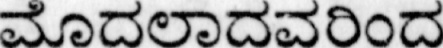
ಮೊದಲಾದವರಿಂದ
